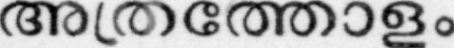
അത്രത്തോളം
